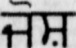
ਜੋਸ਼
